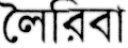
লৈরিবা
